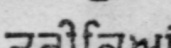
ਤਰੀਕਿਆਂ
